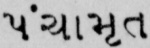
પંચામૃત
